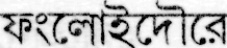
ফংলোইদৌরে
